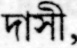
দাসী,
